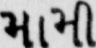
મામી
